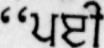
''ਪਈ
